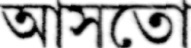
আসতো
